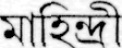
মাহিন্দ্রী
